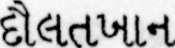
દૌલતખાન
